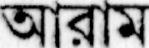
আরাম
